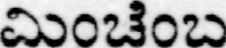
ಮಿಂಚೆಂಬ
